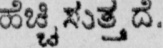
ಹೆಚ್ಚಿಸುತ್ತದೆ.
